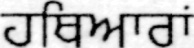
ਹਥਿਆਰਾਂ
